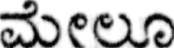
ಮೇಲೂ
